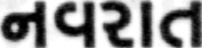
નવરાત
